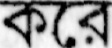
করে
